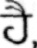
ਹੈ,
